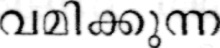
വമിക്കുന്ന
